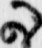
જે
